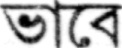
ভাবে
